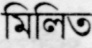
মিলিত
